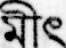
মীৎ
